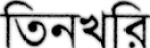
তিনখরি
